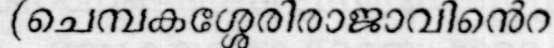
(ചെമ്പകശ്ശേരിരാജാവിന്റെ
